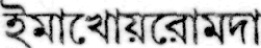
ইমাখোয়রোমদা
